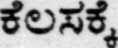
ಕೆಲಸಕ್ಕೆ
